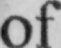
of
